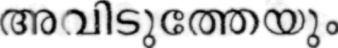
അവിടുത്തേയും
